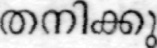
തനിക്കു
